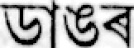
ডাঙৰ
